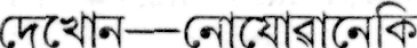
দেখোন-নোযোৱানেকি
